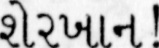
શેરખાન!
